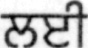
ਲਈ
